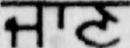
ਜਾਣ
